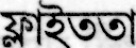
ফ্লাইততা
